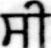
ਸੀ
